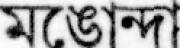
মঙোন্দা
